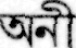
অনী
